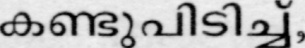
കണ്ടുപിടിച്ച്,
